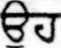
ਉਹ
